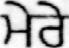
ਮੇਰੇ
